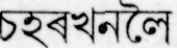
চহৰখনলৈ
